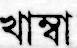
খাম্বা
